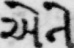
એને
